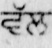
ਵੱਲ
